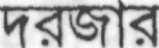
দরজার
